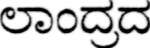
ಲಾಂದ್ರದ
